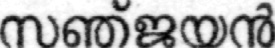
സഞ്ജയന്‍
